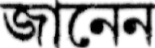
জানেন
